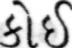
કોઈ
